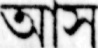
আস
